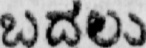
ಬದಲು
